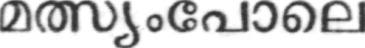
മത്സ്യംപോലെ
